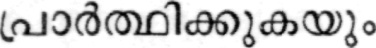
പ്രാര്‍ത്ഥിക്കുകയും
